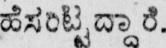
ಹೆಸರಿಟ್ಟಿದ್ದಾರೆ.
